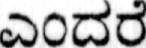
ಎಂದರೆ
